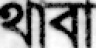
থাবা
